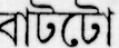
বাটটো
